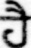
ਹੈ
